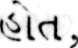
હોત,
